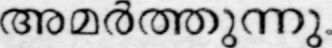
അമര്‍ത്തുന്നു.
